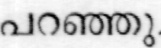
പറഞ്ഞു.
